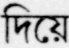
দিয়ে
